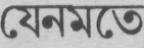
যেনমতে
